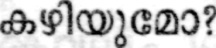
കഴിയുമോ?
